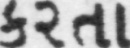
કરતા
